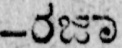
-ರಜಾ
